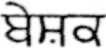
ਬੇਸ਼ਕ
